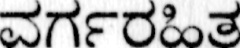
ವರ್ಗರಹಿತ
